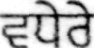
ਵਧੇਰੇ
